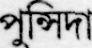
পুন্সিদা
